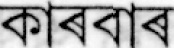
কাৰবাৰ
